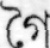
গৈ
